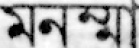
মনম্মা
